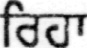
ਰਿਹਾ
